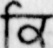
ਕਿ
